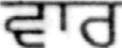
ਵਾਰ
